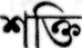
শক্তি
